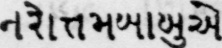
નરોત્તમબાબુએ
